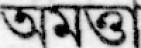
অমত্তা
